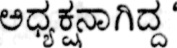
ಅಧ್ಯಕ್ಷನಾಗಿದ್ದ'
